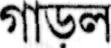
গাড়ল
